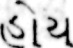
હોય
